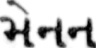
મેનન
